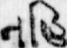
નહિ
